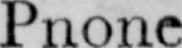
Phone
